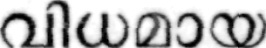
വിധമായ
